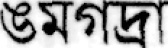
ঙমগদ্রা
